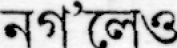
নগ'লেও
